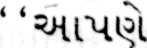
"આપણે
